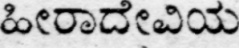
ಹೀರಾದೇವಿಯ
